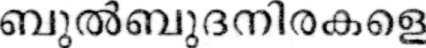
ബുല്‍ബുദനിരകളെ
